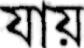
যায়
